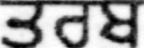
ਤਰਬ
